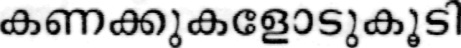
കണക്കുകളോടുകൂടി
